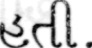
હતી.
